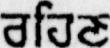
ਰਹਿਣ
